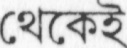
থেকেই
